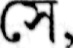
সে,
